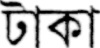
টাকা
